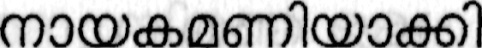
നായകമണിയാക്കി
